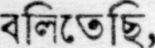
বলিতেছি,
